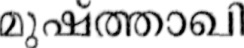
മുഷ്ത്താഖി
